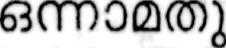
ഒന്നാമതു
